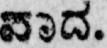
ವಾದ.
